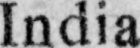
India
